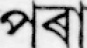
পৰা
